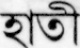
হাতী
